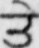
ਤੇ
